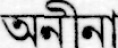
অনীনা
